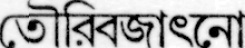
তৌরিবজাৎনো
